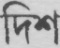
দিশ
